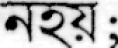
নহয়;
